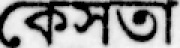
কেসতা
